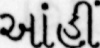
આંહીં
